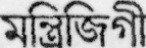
মন্ত্রিজিগী
